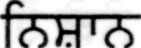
ਨਿਸ਼ਾਨ
